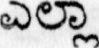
ಎಲ್ಲಾ
